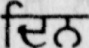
ਦਿਨ
